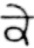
ਕੇ
